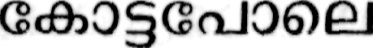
കോട്ടപോലെ
